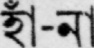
হাঁ-না
